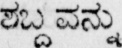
ಶಬ್ದವನ್ನು
